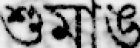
শুমাঙ
